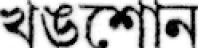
খঙশোন
